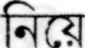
নিয়ে
